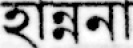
হান্ননা
